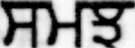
ਸਮਝ
